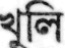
খুলি
